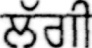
ਲੱਗੀ
